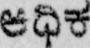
ಅಧಿಕ
